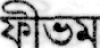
ফীভম
